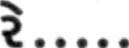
રે..........
